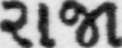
રાજા
